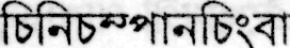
চিনিচম্পানচিংবা
